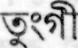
তুংগী
